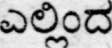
ಎಲ್ಲಿಂದ
